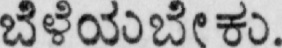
ಬೆಳೆಯಬೇಕು.
